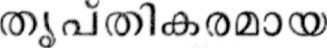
തൃപ്തികരമായ
